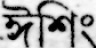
ঈশিং
